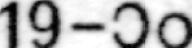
19-ാം
